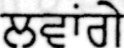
ਲਵਾਂਗੇ
